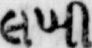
લખી
